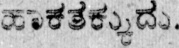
ಹಾಕತಕ್ಕುದು.
